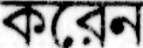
করেন
